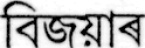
বিজয়াৰ
